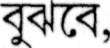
বুঝবে,
